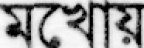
মখোয়
